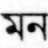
মন
